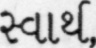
સ્વાર્થ,
